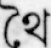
থৈ
